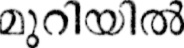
മുറിയില്‍
